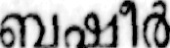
ബഷീര്‍
